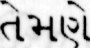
તેમણે
